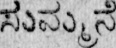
ಸುಮ್ಮನೆ
